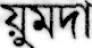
য়ুমদা
